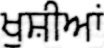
ਖੁਸ਼ੀਆਂ
